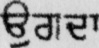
ਉਗਦਾ
